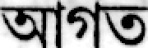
আগত
